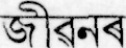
জীৱনৰ
